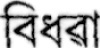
বিধৱা
